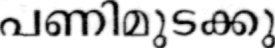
പണിമുടക്കു
